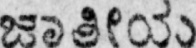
ಜಾತೀಯ
